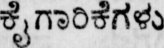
ಕೈಗಾರಿಕೆಗಳು
